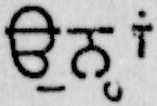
ਉਨ੍ਹਾਂ
